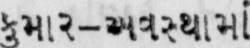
કુમાર-અવસ્થામાં
